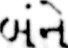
બંને
